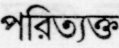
পরিত্যক্ত
